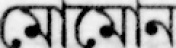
মোমোন
